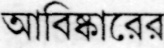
আবিষ্কারের
